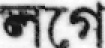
লগে
